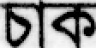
চাক
